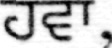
ਹਵਾ,
